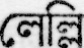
লেল্লি
